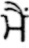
ਮੈਂ
